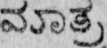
ಮಾತ್ರ
